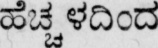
ಹೆಚ್ಚಳದಿಂದ
